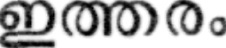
ഇത്തരം
